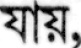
যায়,
